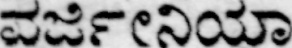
ವರ್ಜೀನಿಯಾ
